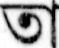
তা
